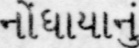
નોંધાયાનું
